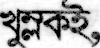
খুম্লকই,
